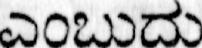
ಎಂಬುದು
